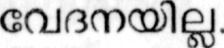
വേദനയില്ല.
